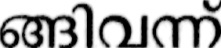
ങ്ങിവന്ന്
